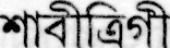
শাবীত্রিগী
